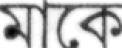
মাকে
